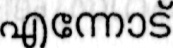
എന്നോട്
